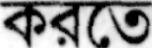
করতে
